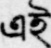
এই
